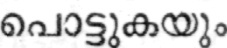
പൊട്ടുകയും
